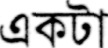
একটা
